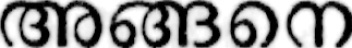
അങ്ങനെ
